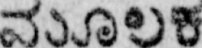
ಮೂಲಕ
